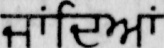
ਜਾਂਦਿਆਂ
